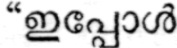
“ഇപ്പോള്‍
